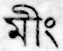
মীং
